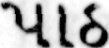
પાઠ
